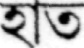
হাত
